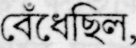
বেঁধেছিল,
